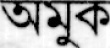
অমুক
